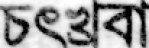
চৎখ্রবা
